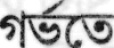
গর্ভতে
